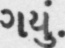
ગયું.
